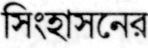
সিংহাসনের
